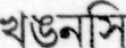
খঙনসি
